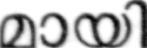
മായി
